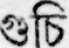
গুচি
